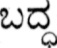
ಬದ್ಧ
